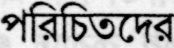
পরিচিতদের
